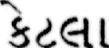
કેટલા
